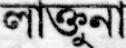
লাক্তুনা
